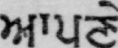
ਆਪਣੇ
